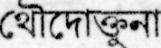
থৌদোক্তুনা
